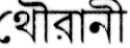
থৌরানী
